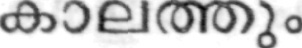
കാലത്തും
